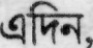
এদিন,
